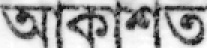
আকাশত
